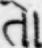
તો
